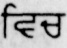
ਵਿਚ
